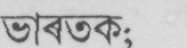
ভাৰতক;
